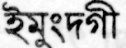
ইমুংদগী
